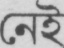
নেই
